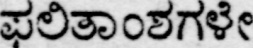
ಫಲಿತಾಂಶಗಳೇ
